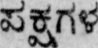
ಪಕ್ಷಗಳ
